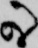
જે
